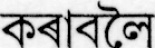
কৰাবলৈ
